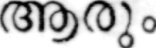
ആരും
